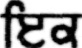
ਇਕ
